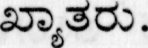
ಖ್ಯಾತರು.
